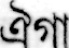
ঐগা
